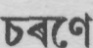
চৰণে
